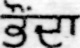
ਭੌਂਦਾ
